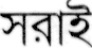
সরাই
